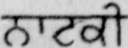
ਨਾਟਕੀ
